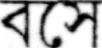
বসে
